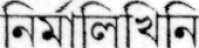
নির্মালিখিনি
